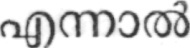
എന്നാല്‍
